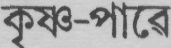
কৃষ্ণ-পাৱে
